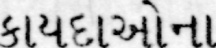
કાયદાઓના
